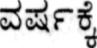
ವರ್ಷಕ್ಕೆ
